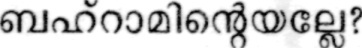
ബഹ്റാമിന്റെയല്ലേ?
